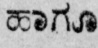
ಹಾಗೂ
